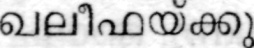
ഖലീഫയ്ക്കു
